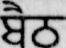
ਬੈਠ
